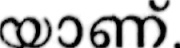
യാണ്.
